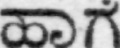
ಹಾಗೆ
